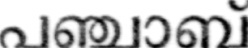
പഞ്ചാബ്
